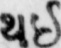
થઈ
